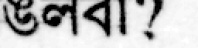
ঙলবা!
